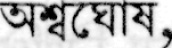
অশ্বঘোষ,
